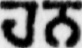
ਹਨ
